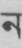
ন
